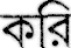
করি
